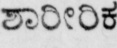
ಶಾರೀರಿಕ
